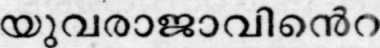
യുവരാജാവിന്റെ
